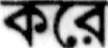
করে
